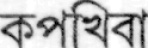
কপখিবা
